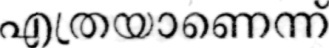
എത്രയാണെന്ന്
